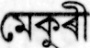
মেকুৰী
